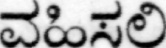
ವಹಿಸಲಿ
